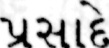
પ્રસાદે
